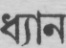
ধ্যান
